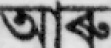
আৰু
